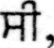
ਸੀ,
